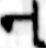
ન
